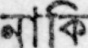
নাকি
